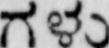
ಗಳು
